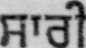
ਸਾਰੀ
